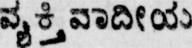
ವ್ಯಕ್ತಿವಾದೀಯ
